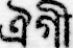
ঐগী
